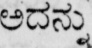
ಅದನ್ನು
